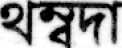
থম্বদা
